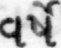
વર્ષે
